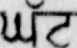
ਘੱਟ
